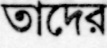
তাদের
